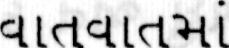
વાતવાતમાં
